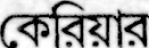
কেরিয়ার
